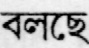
বলছে
